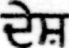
ਦੇਸ਼
